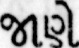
જાણે
